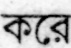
করে
